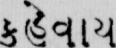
કહેવાય
